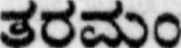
ತರಮಂ
